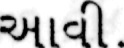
આવી.
